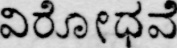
ವಿರೋಧವೆ
